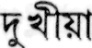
দুখীয়া
